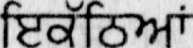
ਇਕੱਠਿਆਂ
